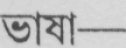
ভাষা-
